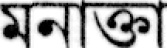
মনাক্তা
